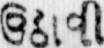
ઉઠાવી
